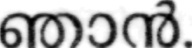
ഞാന്‍.
